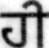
ਹੀ
